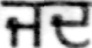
ਜਦ
